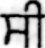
ਸੀ
